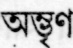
অম্ভৃণ
